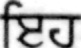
ਇਹ
